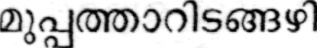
മുപ്പത്താറിടങ്ങഴി
